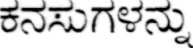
ಕನಸುಗಳನ್ನು
